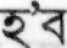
হ'ব
